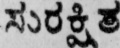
ಸುರಕ್ಷಿತ
